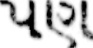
પણ
